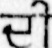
ਦੀ
